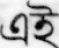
এই
